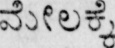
ಮೇಲಕ್ಕೆ
